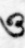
ও
